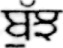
ਬੁੱਝ
